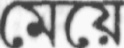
মেয়ে
